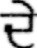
ਦੇ
